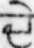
ਦੇ
